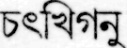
চৎখিগনু
